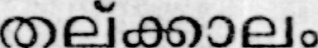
തല്ക്കാലം
